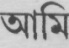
আমি
